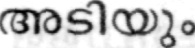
അടിയും
